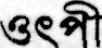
ওৎপী
